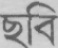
ছবি
